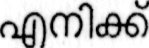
എനിക്ക്
